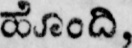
ಹೊಂದಿ,
